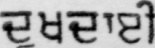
ਦੁਖਦਾਈ
